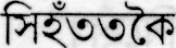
সিহঁততকৈ
